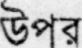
উপর
